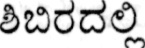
ಶಿಬಿರದಲ್ಲಿ
